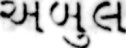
અબુલ
